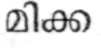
മിക്ക
